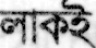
লাকই
